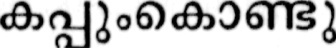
കപ്പുംകൊണ്ടു
